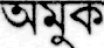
অমুক
